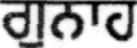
ਗੁਨਾਹ
